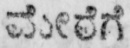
ಮೇರೆಗೆ
